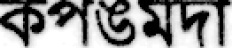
কপঙমদা
